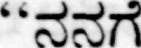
"ನನಗೆ
